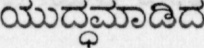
ಯುದ್ಧಮಾಡಿದ
